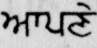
ਆਪਣੇ
